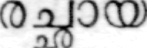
രച്ഛായ
